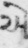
એ
